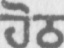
ਹੋਠ
